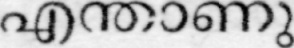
എന്താണു
